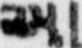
આ
